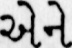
એને
